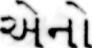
એનો
